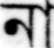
না
